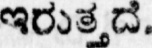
ಇರುತ್ತದೆ.
